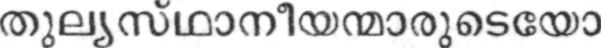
തുല്യസ്ഥാനീയന്മാരുടെയോ
